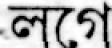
লগে
